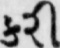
કરી?
